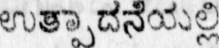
ಉತ್ಪಾದನೆಯಲ್ಲಿ
